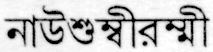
নাউশুম্বীরম্মী
